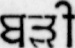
ਬੜੀ
